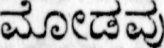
ಮೋಡವು
